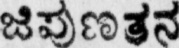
ಜಿಪುಣತನ
